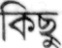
কিছু
